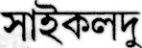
সাইকলদু
